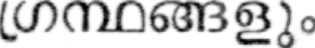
ഗ്രന്ഥങ്ങളും
